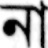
না
